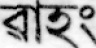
ৱাহং
